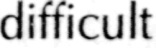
difficult
